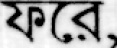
ফরে,
